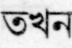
তখন
